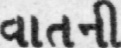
વાતની
